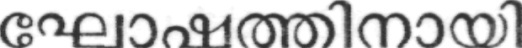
ഘോഷത്തിനായി
